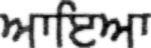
ਆਇਆ
